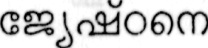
ജ്യേഷ്ഠനെ
